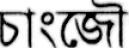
চাংজৌ
